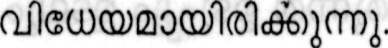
വിധേയമായിരിക്കുന്നു.
